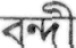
বন্দী
